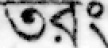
তরং
